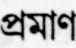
প্রমাণ
